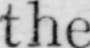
the
